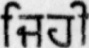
ਜਿਹੀ
